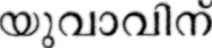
യുവാവിന്
